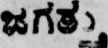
ಜಗತ್ತು
